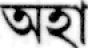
অহা
